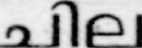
ചില
